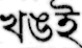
খঙই
